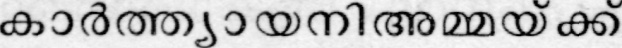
കാര്‍ത്ത്യായനിഅമ്മയ്ക്ക്
